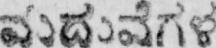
ಮದುವೆಗಳ
